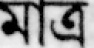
মাত্র
